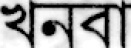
খনবা
